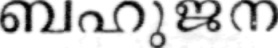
ബഹുജന
